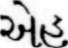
એહ
